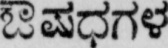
ಔಷಧಗಳ
